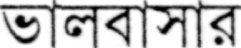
ভালবাসার
